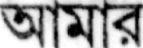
আমার
